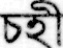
চহী
